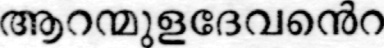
ആറന്മുളദേവന്റെ
